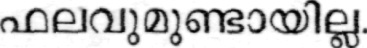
ഫലവുമുണ്ടായില്ല.
